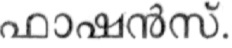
ഫാഷന്‍സ്.
